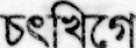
চৎখিগে
